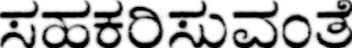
ಸಹಕರಿಸುವಂತೆ
